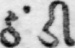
ઠંડી
